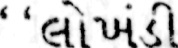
"લોખંડી
